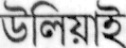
উলিয়াই
